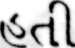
હતી
